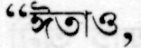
“ঈতাও,
